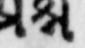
પ્રશ્ન
